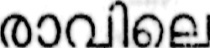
രാവിലെ
